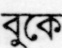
বুকে
